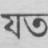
যত
